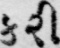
કરી
